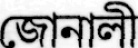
জোনালী
